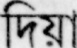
দিয়া
